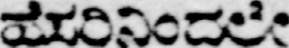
ಹೆಸರಿನಿ೦ದಲೇ
